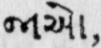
જાઓ,
